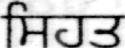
ਸਿਹਤ
